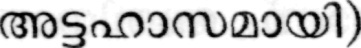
അട്ടഹാസമായി)
